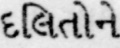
દલિતોને
